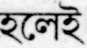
হলেই
